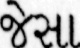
જેસા
